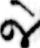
જે
